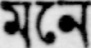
মনে
